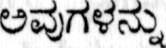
ಅವುಗಳನ್ನು
